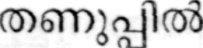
തണുപ്പില്‍
